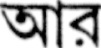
আর
